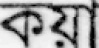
কয়া
